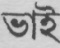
ভাই
